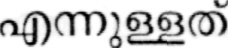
എന്നുള്ളത്
